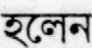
হলেন
